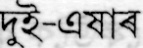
দুই-এষাৰ
